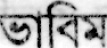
ভাবিম
